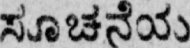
ಸೂಚನೆಯ
